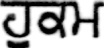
ਹੁਕਮ
